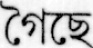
গৈছে
